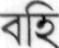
বহি
